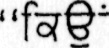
''ਕਿਉਂ
